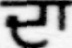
ਦਾ
